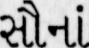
સૌનાં
